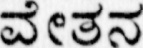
ವೇತನ
